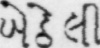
બેઠલી
